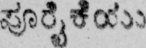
ಪೂರೈಕೆಯು
